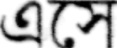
এসে
